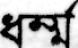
ধর্ম্ম
